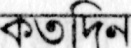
কতদিন
